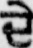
ਦੇ
